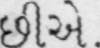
છીએ.
